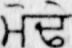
ਮੋਢੇ
